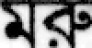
মরু
